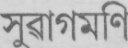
সুৱাগমণি
